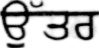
ਉੱਤਰ
